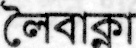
লৈবাক্না
